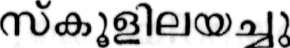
സ്കൂളിലയച്ചു
